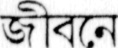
জীবনে
